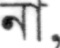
না,
